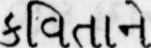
કવિતાને
